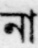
না
